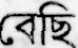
বেছি
